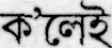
ক'লেই
